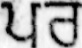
ਪਰ
